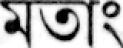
মতাং
